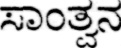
ಸಾಂತ್ವನ
